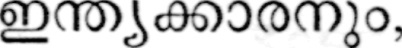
ഇന്ത്യക്കാരനും,
